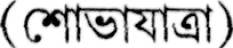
(শোভাযাত্রা)
